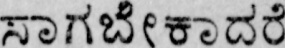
ಸಾಗಬೇಕಾದರೆ
